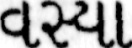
વસ્યા
